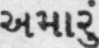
અમારું
